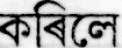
কৰিলে
